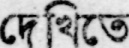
দেখিতে
